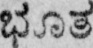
ಭೂತ
